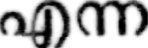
എന്ന
